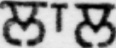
ਲਾਲ
